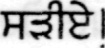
ਸੜੀਏ!
